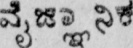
ವೈಜ್ಞಾನಿಕ
